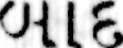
બાદ
